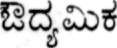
ಔದ್ಯಮಿಕ
